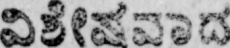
ವಿಶೇಷವಾದ
